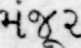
મંજૂર
